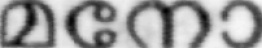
മനോ
